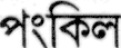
পংকিল
